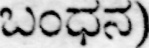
ಬಂಧನ)
